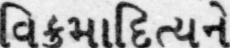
વિક્રમાદિત્યને
